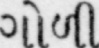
ગોળી
